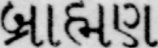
બ્રાહ્મણ
